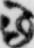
છે
